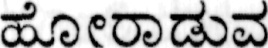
ಹೋರಾಡುವ
